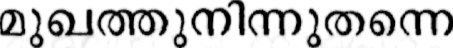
മുഖത്തുനിന്നുതന്നെ
